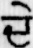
ਦੇ
